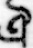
ঐ
